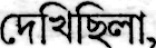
দেখিছিলা,
